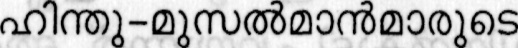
ഹിന്തു-മുസല്‍മാന്‍മാരുടെ
